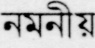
নমনীয়
